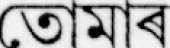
তোমাৰ
